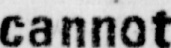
cannot
